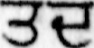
ਤਦ
